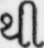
થી
